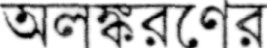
অলঙ্করণের
